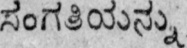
ಸಂಗತಿಯನ್ನು
